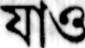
যাও
